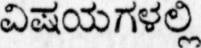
ವಿಷಯಗಳಲ್ಲಿ
